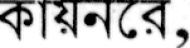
কায়নরে,
